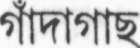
গাঁদাগাছ
